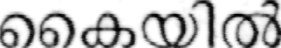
കൈയില്‍
